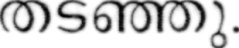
തടഞ്ഞു.
